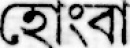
হোংবা
